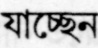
যাচ্ছেন
